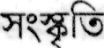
সংস্কৃতি
